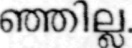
ഞ്ഞില്ല.
